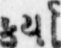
કર્યા
